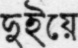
দুইয়ে
